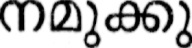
നമുക്കു
